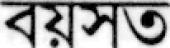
বয়সত
